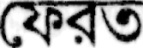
ফেরত
